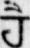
ਹੈ
